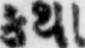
કથા
